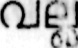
വല്ല
